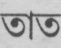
তাত
